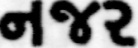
નજર
